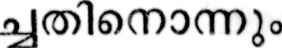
ച്ചതിനൊന്നും
